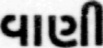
વાણી
